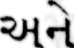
અને
